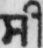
ਸੀ
